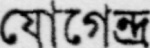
যোগেন্দ্র
